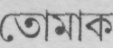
তোমাক
